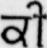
ਕੀ
